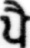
ਪੈ
